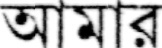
আমার
